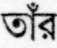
তাঁর
